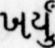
ખર્યું
